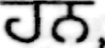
ਹਨ,
